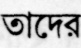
তাদের
